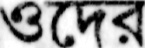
ওদের
